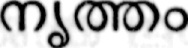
നൃത്തം
